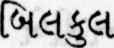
બિલકુલ
